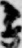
કે
